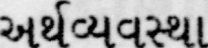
અર્થવ્યવસ્થા
